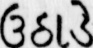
ઉઠાડે
